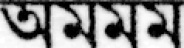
অমমম
